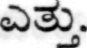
ಎತ್ತು.
